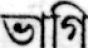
ভাগি
